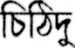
চিঠিদু
